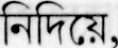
নিদিয়ে,
